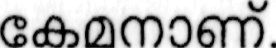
കേമനാണ്.
